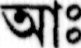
আঃ
